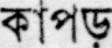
কাপড়
